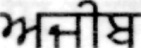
ਅਜੀਬ
